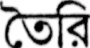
তৈরি
